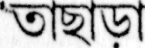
তাছাড়া
